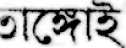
তাঙ্গোই
